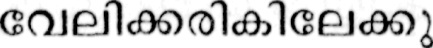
വേലിക്കരികിലേക്കു
